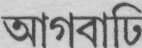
আগবাঢ়ি
